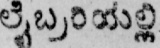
ಲೈಬ್ರರಿಯಲ್ಲಿ
